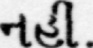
નહીં.
